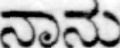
ನಾನು
